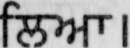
ਲਿਆ।
